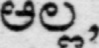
ಅಲ್ಲ,
